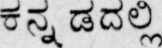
ಕನ್ನಡದಲ್ಲಿ
